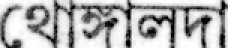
থোঙ্গালদা
